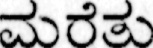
ಮರೆತು
